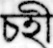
চহী
